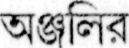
অঞ্জলির
